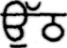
ਉੱਠ
